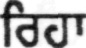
ਰਿਹਾ
